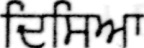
ਦਿਸਿਆ
